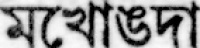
মখোঙদা
